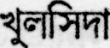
খুলসিদা
